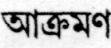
আক্রমণ
